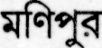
মণিপুর
